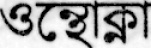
ওন্থোক্না
